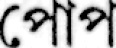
পোপ
